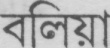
বলিয়া
